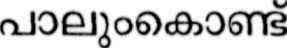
പാലുംകൊണ്ട്
